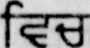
ਵਿਚ
